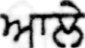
ਆਲੇ
